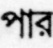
পার
